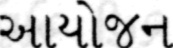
આયોજન
